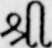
શ્રી
